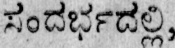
ಸಂದರ್ಭದಲ್ಲಿ,
